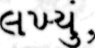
લખ્યું,
